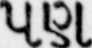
પણ
